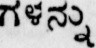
ಗಳನ್ನು
